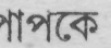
পাপকে
